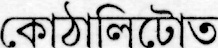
কোঠালিটোত
